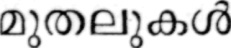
മുതലുകള്‍
